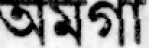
অমগা
